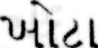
ખોટા
